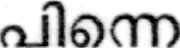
പിന്നെ
